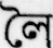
লৈ
